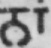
ਨਾਂ
